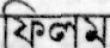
ফিলম
